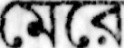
মেরে
